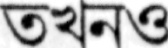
তখনও
